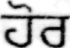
ਹੋਰ
